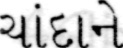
ચાંદાને
